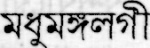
মধুঙ্গলগী
